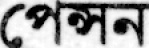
পেন্সন
